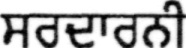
ਸਰਦਾਰਨੀ
